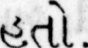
હતો.
